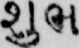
શુભ
